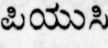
ಪಿಯುಸಿ
